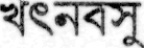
খৎনবসু
